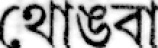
থোঙবা
